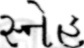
સ્નેહ
